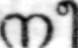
നീ
